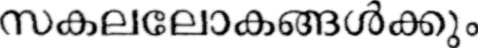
സകലലോകങ്ങള്‍ക്കും
